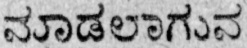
ಮಾಡಲಾಗುವ
